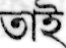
তাই
